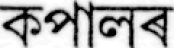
কপালৰ
